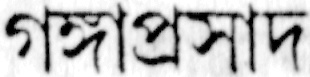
গঙ্গাপ্রসাদ
